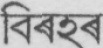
বিৰহৰ
